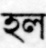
হল
